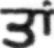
ਤਾਂ
